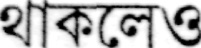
থাকলেও
